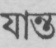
যান্ত
